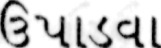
ઉપાડવા
